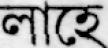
লাহে
